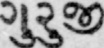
ગુરુજી
